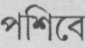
পশিবে
